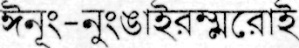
ঈনূং-নুংঙাইরম্মরোই
